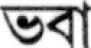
ভবা
